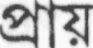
প্রায়
